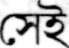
সেই
